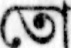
তো
